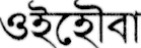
ওইহৌবা
